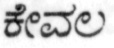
ಕೇವಲ
